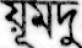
য়ুমদু
